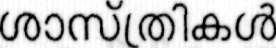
ശാസ്ത്രികള്‍
